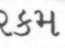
રકમ
